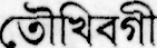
তৌখিবগী
